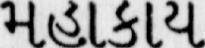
મહાકાય
